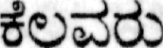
ಕೆಲವರು
